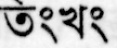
তিংখং
